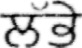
ਲੱਭੇ
